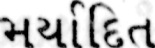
મર્યાદિત
